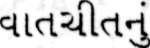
વાતચીતનું
